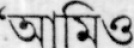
'আমিও
